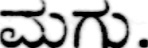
ಮಗು.
